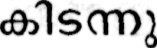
കിടന്നു
